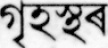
গৃহস্থৰ
